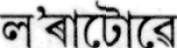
ল'ৰাটোৱে
